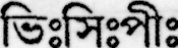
ভিঃসিঃপিঃ
